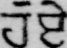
ਹੋਏ
